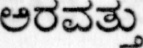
ಅರವತ್ತು
